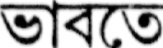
ভাবতে
